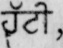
ਹੱਟੀ,
